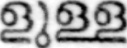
ളുള്ള
